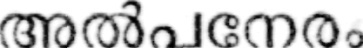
അല്‍പനേരം
